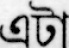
এটা
